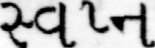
સ્વપ્ન
